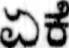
ಏಕೆ
